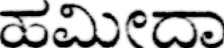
ಹಮೀದಾ
